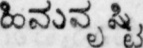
ಹಿಮವೃಷ್ಟಿ
